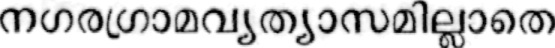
നഗരഗ്രാമവ്യത്യാസമില്ലാതെ
